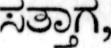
ಸತ್ತಾಗ,
